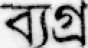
ব্যগ্ৰ
